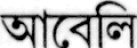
আবেলি
